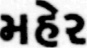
મહેર
